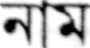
নাম
